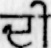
ਦੀ
